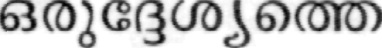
ഒരുദ്ദേശ്യത്തെ
